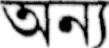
অন্য
